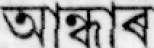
আন্ধাৰ
